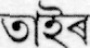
তাইৰ
